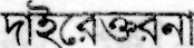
দাইরেক্তরনা
